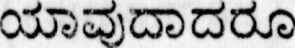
ಯಾವುದಾದರೂ
